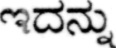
ಇದನ್ನು
